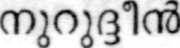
നുറുദ്ദീന്‍
